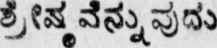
ಶ್ರೇಷ್ಠವೆನ್ನುವುದು
